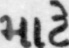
માટે
